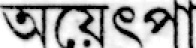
অয়েৎপা
